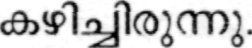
കഴിച്ചിരുന്നു.
